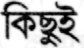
কিছুই
